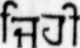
ਜਿਹੀ
